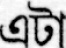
এটা
